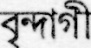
বৃন্দাগী
